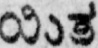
ಯಿತ
